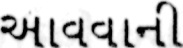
આવવાની
